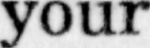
your
